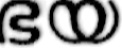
ഭയ
